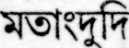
মতাংদুদি
